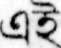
এই
